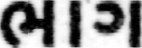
ભાગ
